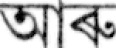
আৰু
